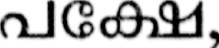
പക്ഷേ,
